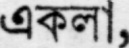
একলা,
